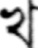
খ
